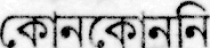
কোনকোননি
